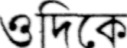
ওদিকে
